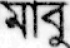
মাবু
